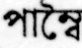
পাম্বৈ
